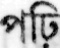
পঢ়ি
